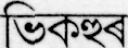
ভিকহুৰ
